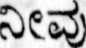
ನೀವು
